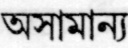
অসামান্য
